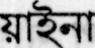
য়াইনা
